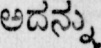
ಅದನ್ನು
